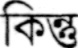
কিন্তু
